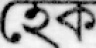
হেক
